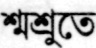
শ্মশ্রুতে
